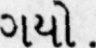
ગયો.
